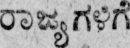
ರಾಜ್ಯಗಳಿಗೆ
